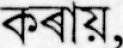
কৰায়,
